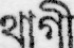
থাগী
